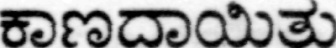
ಕಾಣದಾಯಿತು
